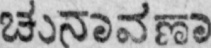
ಚುನಾವಣಾ
